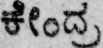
ಕೇಂದ್ರ
